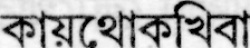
কায়থোকখিবা
